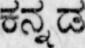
ಕನ್ನಡ
